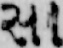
સા
